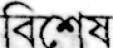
বিশেষ
